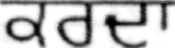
ਕਰਦਾ
